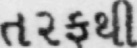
તરફથી
